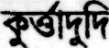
কুর্ত্তাদুদি
